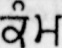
ਕੰਮ
